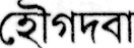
হৌগদবা
